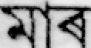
মাৰ
